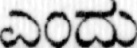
ಎಂದು
